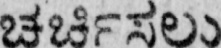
ಚರ್ಚಿಸಲು
